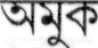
অমুক
